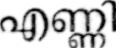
എണ്ണി
